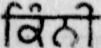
ਕਿੰਨੀ
